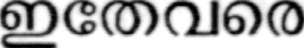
ഇതേവരെ
